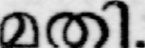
മതി.
